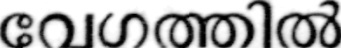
വേഗത്തില്‍
